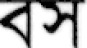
বস
